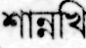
শান্নখি
